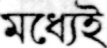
মধ্যেই
